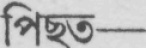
পিছত-
